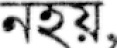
নহয়,
